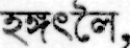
হঙ্গৎলৈ,
